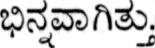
ಭಿನ್ನವಾಗಿತ್ತು.
